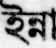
ইন্না
